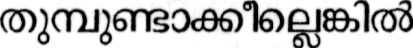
തുമ്പുണ്ടാക്കീല്ലെങ്കില്‍
